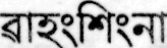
ৱাহংশিংনা
